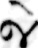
જે
